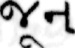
જૂન
